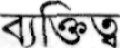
ব্যক্তিত্ব
